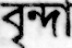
বৃন্দা
